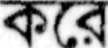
করে
